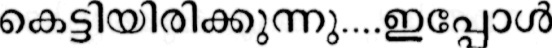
കട്ടിയിരിക്കുന്നു....ഇപ്പോള്‍
